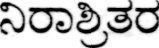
ನಿರಾಶ್ರಿತರ
